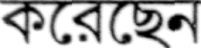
করেছেন
